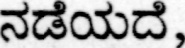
ನಡೆಯದೆ,
